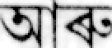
আৰু
